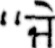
''ਜੇ
